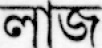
লাজ
